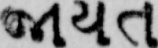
જાયત
